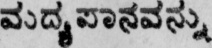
ಮದ್ಯಪಾನವನ್ನು
